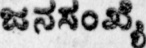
ಜನಸಂಖ್ಯೆ
